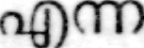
എന്ന
